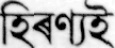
হিৰণ্যই
